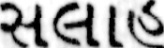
સલાહ
